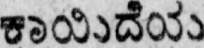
ಕಾಯಿದೆಯ
